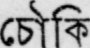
চৌকি
